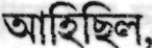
আহিছিল,
